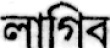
লাগিব
